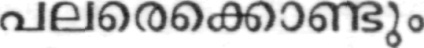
പലരെക്കൊണ്ടും
